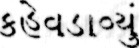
કહેવડાવ્યું
